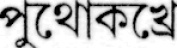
পুথোকখ্রে
